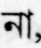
না,
